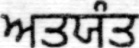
ਅਤਯੰਤ
